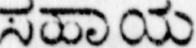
ಸಹಾಯ
